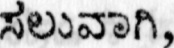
ಸಲುವಾಗಿ,
